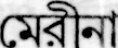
মেরীনা
